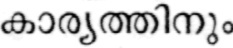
കാര്യത്തിനും
